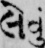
લેવું
